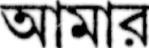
আমার
